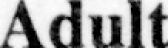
Adult
